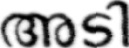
അടി
